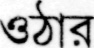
ওঠার
